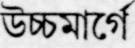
উচ্চমার্গে
